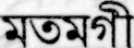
মতমগী
